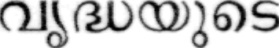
വൃദ്ധയുടെ
